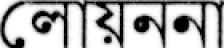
লোয়ননা
